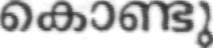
കൊണ്ടു
